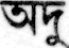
অদু
